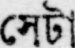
সেটা
